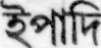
ইপাদি
